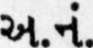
અ.નં.
